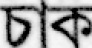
চাক
